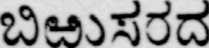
ಬಿಱುಸರದ
